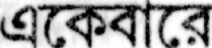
একেবারে
